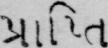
પ્રાપ્તિ
